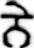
ਨੇ
